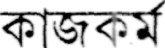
কাজকর্ম
